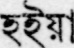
হইয়া
